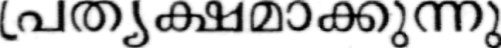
പ്രത്യക്ഷമാക്കുന്നു
